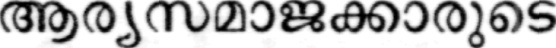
ആര്യസമാജക്കാരുടെ
